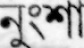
নুংশা
